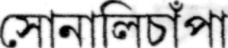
সোনালিচাঁপা
